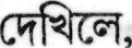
দেখিলে,
